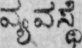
ವ್ಯವಸ್ಥೆ
